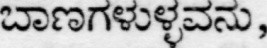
ಬಾಣಗಳುಳ್ಳವನು,
